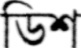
ডিশ
